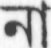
না
